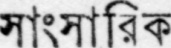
সাংসারিক
